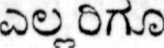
ಎಲ್ಲರಿಗೂ
